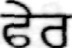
ਫੇਰ
